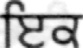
ਇਕ
